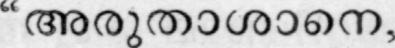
"അരുതാശാനെ,
